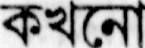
কখনো
